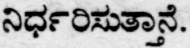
ನಿರ್ಧರಿಸುತ್ತಾನೆ.
